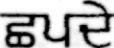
ਛਪਦੇ
